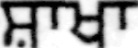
ਸ਼ਾਖਾ
